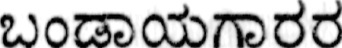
ಬಂಡಾಯಗಾರರ
